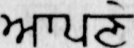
ਆਪਣੇ
